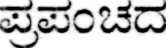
ಪ್ರಪಂಚದ
